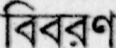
বিবরণ
